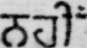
ਨਹੀਂ
